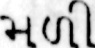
મળી
